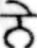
ਨੇ
